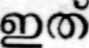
ഇത്
